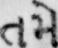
તમે
